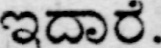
ಇದಾರೆ.
